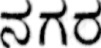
ನಗರ
